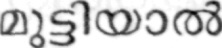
മുട്ടിയാല്‍
